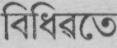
বিধিৱতে
